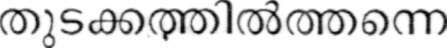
തുടക്കത്തില്‍ത്തന്നെ
